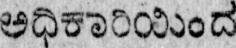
ಅಧಿಕಾರಿಯಿಂದ
